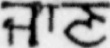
ਜਾਣ
